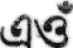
এওঁ
